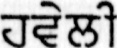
ਹਵੇਲੀ
